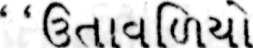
"ઉતાવળિયો
